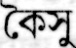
কৈসু
